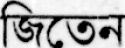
জিতেন
